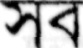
সব
